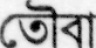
তৌবা
